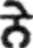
ਨੇ
